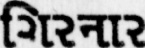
ગિરનાર
